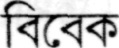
বিবেক
